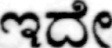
ಇದೇ
